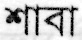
শাবা
